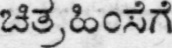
ಚಿತ್ರಹಿಂಸೆಗೆ
